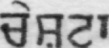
ਚੇਸ਼ਟਾ
